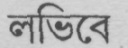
লভিবে
